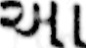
આ
